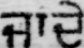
ਜਾਂਦੇ
